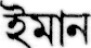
ইমান
